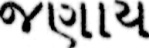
જણાય
